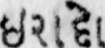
ઇરાદો
